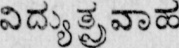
ವಿದ್ಯುತ್ಪ್ರವಾಹ
